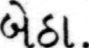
બેઠા.
